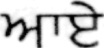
ਆਏ
